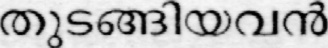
തുടങ്ങിയവന്‍
